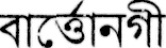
বার্ত্তোনগী
